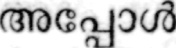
അപ്പോള്‍
